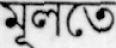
মূলতে
